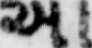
આ
